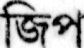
জিপ
